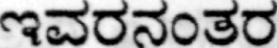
ಇವರನಂತರ
